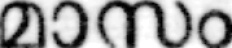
മാസം
